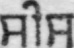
ਸੀਸ
